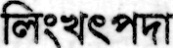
লিংখৎপদা
